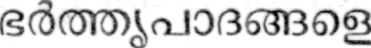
ഭര്‍ത്തൃപാദങ്ങളെ
